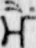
ਮੈਂ
